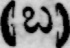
(ಬ)
